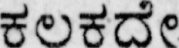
ಕಲಕದೇ
